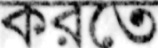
করতে
